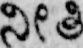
ನೀತಿ
